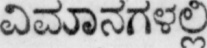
ವಿಮಾನಗಳಲ್ಲಿ
